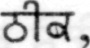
ਠੀਕ,
